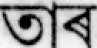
তাৰ
